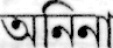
অনিনা
